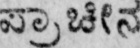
ಪ್ರಾಚೀನ
